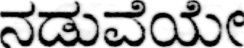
ನಡುವೆಯೇ
